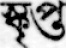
স্কৃপ্ত
